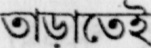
তাড়াতেই
